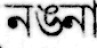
নঙনা
